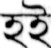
হই
